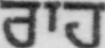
ਰਾਹ
